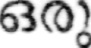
ഒരു
